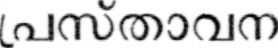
പ്രസ്താവന
